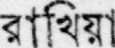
রাখিয়া
